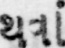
થવાં
